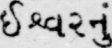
ઈશ્વરનું
